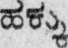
ಹಕ್ಕು
